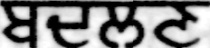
ਬਦਲਣ
